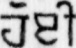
ਹੋਈ
